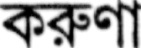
করুণা
